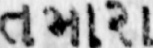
તમારા
